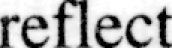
reflect
